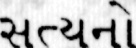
સત્યનો
